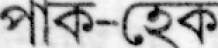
পাক-হেক
